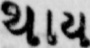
થાય
